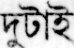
দুটাই
